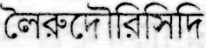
লৈরুদৌরিসিদি
